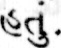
હતું.
